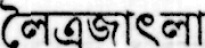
লৈত্রজাৎলা
